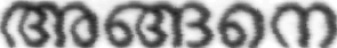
അങ്ങനെ
